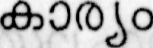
കാര്യം
